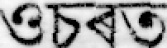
ওচৰত
